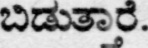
ಬಿಡುತ್ತಾರೆ.
